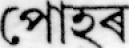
পোহৰ
